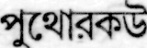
পুথোরকউ
